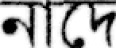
নাদে
